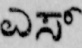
ಎಸ್
